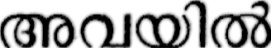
അവയില്‍
